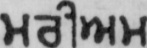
ਮਰੀਅਮ
